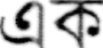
এক
